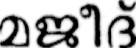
മജീദ്
